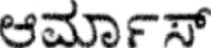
ಆರ್ಮಾಸ್
